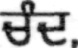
ਚੰਦ,
